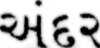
અંદર
